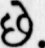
છે.
